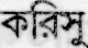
করিসু
